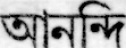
আনন্দি
